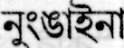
নুংঙাইনা
